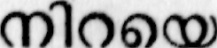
നിറയെ
